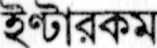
ইণ্টারকম
